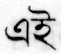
এই
